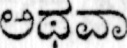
ಅಥವಾ
